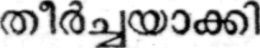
തീര്‍ച്ചയാക്കി
